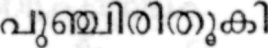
പുഞ്ചിരിതൂകി
